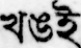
খঙই
